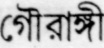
গৌরাঙ্গী
